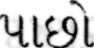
પાછો
